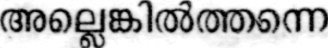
അല്ലെങ്കില്‍ത്തന്നെ
